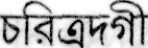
চরিত্রদগী
